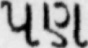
પણ
